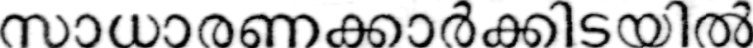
സാധാരണക്കാര്‍ക്കിടയില്‍
